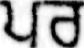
ਪਰ
